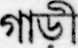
গাড়ী
